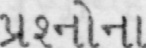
પ્રશ્નોના
